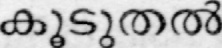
കൂടുതല്‍
